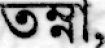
তম্না,
